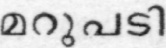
മറുപടി
